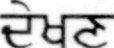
ਦੇਖਣ
